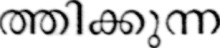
ത്തിക്കുന്ന
